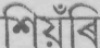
শিয়ঁৰি
